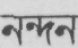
নন্দন
